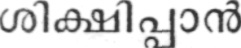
ശിക്ഷിപ്പാന്‍
